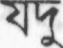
যদু
